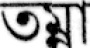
তম্না
